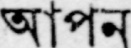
আপন
